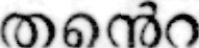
തന്റെ
